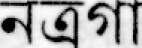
নত্রগা
